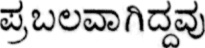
ಪ್ರಬಲವಾಗಿದ್ದವು
